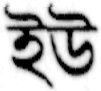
ইউ
